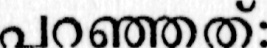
പറഞ്ഞത്:
